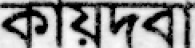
কায়দবা
